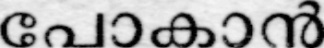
പോകാന്‍
